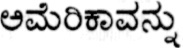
ಅಮೆರಿಕಾವನ್ನು
